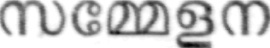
സമ്മേളന
